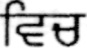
ਵਿਚ
